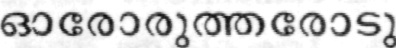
ഓരോരുത്തരോടു
